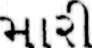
મારી
